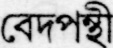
বেদপন্থী
